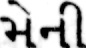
મેની
